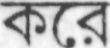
করে
